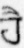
ਹੈ
